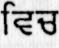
ਵਿਚ
